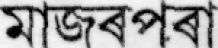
মাজৰপৰা
